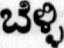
ಬೆಳ್ಳಿ
